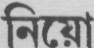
নিয়ো
